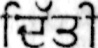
ਦਿੱਤੀ
